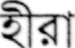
হীরা
